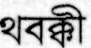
থবক্কী
